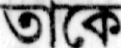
তাকে
